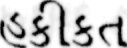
હકીકત
